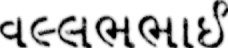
વલ્લભભાઈ
